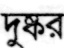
দুষ্কর
